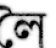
লৈ
